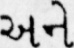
અને
